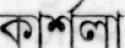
কার্শলা
